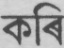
কৰি
